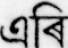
এৰি
